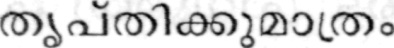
തൃപ്തിക്കുമാത്രം
